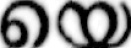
യെ
